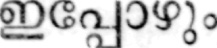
ഇപ്പോഴും
